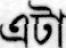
এটা
